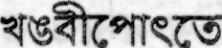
খঙবীপোৎতে
